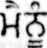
ਮੈਨੂੰ
